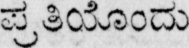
ಪ್ರತಿಯೊಂದು
